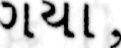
ગયા,
